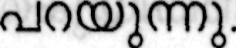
പറയുന്നു.
